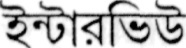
ইন্টারভিউ
